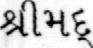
શ્રીમદ્
